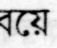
বয়ে
